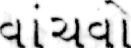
વાંચવો
